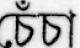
চেঁচা
